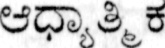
ಆಧ್ಯಾತ್ಮಿಕ
